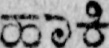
ಹಾಕಿ
